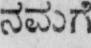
ನಮಗೆ
